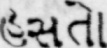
હસતો
